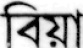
বিয়া
